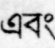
এবং
